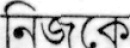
নিজকে
